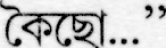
কৈছো..."
